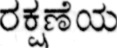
ರಕ್ಷಣೆಯ
